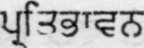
ਪ੍ਰਤਿਭਾਵਨ
